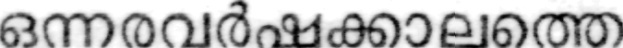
ഒന്നരവര്‍ഷക്കാലത്തെ
